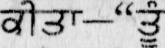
ਕੀਤਾ-''ਤੂੰ
